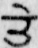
ਤੇ
